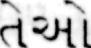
તેઓ
